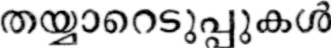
തയ്യാറെടുപ്പുകള്‍
